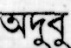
অদুবু
